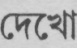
দেখো
